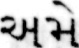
અમે
